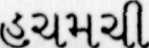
હચમચી
